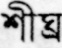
শীঘ্র
